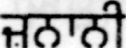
ਜ਼ਨਾਨੀ
